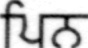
ਪਿਨ
